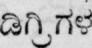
ಡಿಗ್ರಿಗಳ
